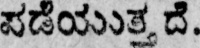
ಪಡೆಯುತ್ತದೆ.
